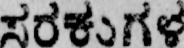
ಸರಕುಗಳ
